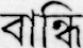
বান্ধি
